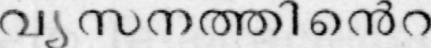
വ്യസനത്തിന്റെ
